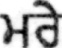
ਮਰੇ
